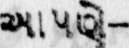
આપણે-
